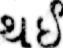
થઈ
